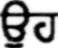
ਉਹ
